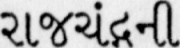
રાજચંદ્રની
